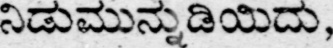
ನಿಡುಮುನ್ನುಡಿಯಿದು,
